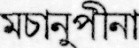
মচানুপীনা
